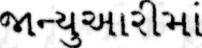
જાન્યુઆરીમાં
